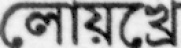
লোয়খ্রে
